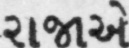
રાજાએ
